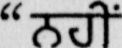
''ਨਹੀਂ
